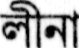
লীনা
